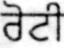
ਰੋਟੀ
